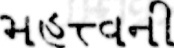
મહત્ત્વની
